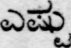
ಎಷ್ಟು
